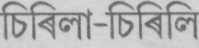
চিৰিলা-চিৰিলি
